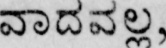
ವಾದವಲ್ಲ,
